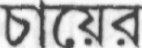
চায়ের
